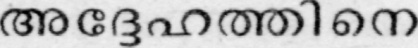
അദ്ദേഹത്തിനെ
